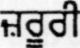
ਜ਼ਰੂਰੀ
